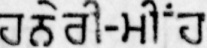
ਹਨੇਰੀ-ਮੀਂਹ
